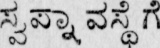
ಸ್ವಪ್ನಾವಸ್ಥೆಗೆ
